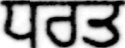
ਧਰਤ
